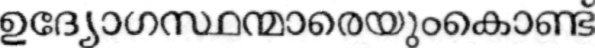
ഉദ്യോഗസ്ഥന്മാരെയുംകൊണ്ട്
